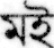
মই
